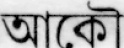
আকৌ
